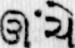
ઊંચે
